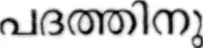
പദത്തിനു
